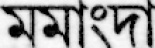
মমাংদা
